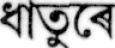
ধাতুৰে
